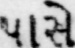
પાસે
